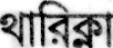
থারিক্না
